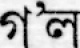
গ'ল
